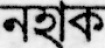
নহাক
